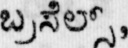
ಬ್ರಸೆಲ್ಸ್,
